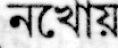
নখোয়
